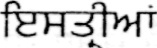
ਇਸਤ੍ਰੀਆਂ
